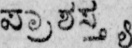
ಪ್ರಾಶಸ್ತ್ಯ
